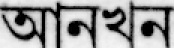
আনখন
